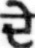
ਦੇ
